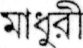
মাধুরী
